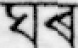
ঘৰ
